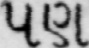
પણ
